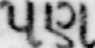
પણ
